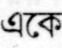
একে
